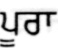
ਪੂਰਾ
